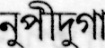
নুপীদুগা
